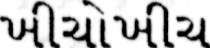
ખીચોખીચ
